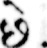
છે.
